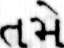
તમે
